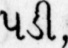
પડી,
